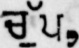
ਚੁੱਪ,
